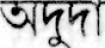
অদুদা
